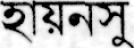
হায়নসু
